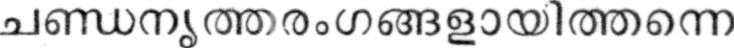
ചണ്ഡനൃത്തരംഗങ്ങളായിത്തന്നെ
